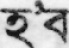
হ'ব
